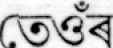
তেওঁৰ
